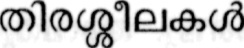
തിരശ്ശീലകള്‍
